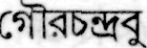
গৌরচন্দ্রবু
